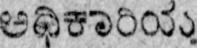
ಅಧಿಕಾರಿಯ
